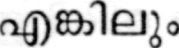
എങ്കിലും
